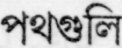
পথগুলি
